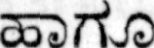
ಹಾಗೂ
